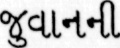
જુવાનની
